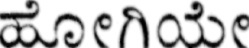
ಹೋಗಿಯೇ
